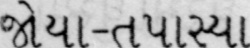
જોયા-તપાસ્યા
